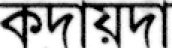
কদায়দা
